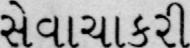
સેવાચાકરી
